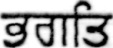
ਭਗਤਿ
